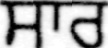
ਸਾਰ
